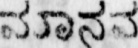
ಮಾನವ
